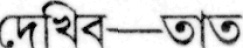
দেখিব-তাত
